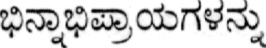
ಭಿನ್ನಾಭಿಪ್ರಾಯಗಳನ್ನು
